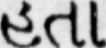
હતા
